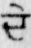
ਦੇ
